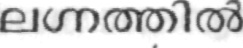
ലഗ്നത്തില്‍
